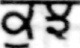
ਕੁਝ
